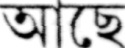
আছে
